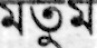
মতুম
